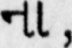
ના,
